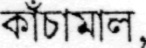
কাঁচামাল,
